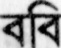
ববি
